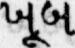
ખૂબ
